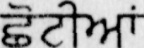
ਛੋਟੀਆਂ
